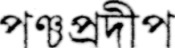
পঞ্চপ্রদীপ
